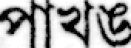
পাখঙ
